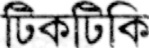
টিকটিকি
